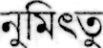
নুমিৎতু
